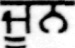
ਜੂਨ
